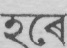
হৰে
